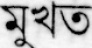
মুখত
